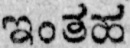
ಇಂತಹ
